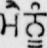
ਮੈਨੂੰ
